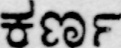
ಕರ್ಣ
